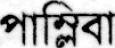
পাম্লিবা
